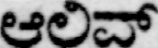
ಆಲಿವ್
